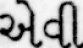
એવી
